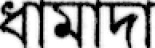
ধামাদা
